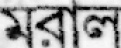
মরাল
